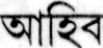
আহিব
